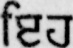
ਇਹ
